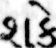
શકે
